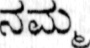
ನಮ್ಮ
